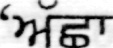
'ਅੱਛਾ
